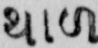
થાળ
